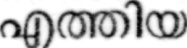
എത്തിയ
